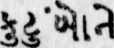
કુટુંબોને
